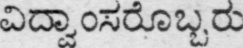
ವಿದ್ವಾಂಸರೊಬ್ಬರು
